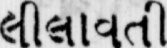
લીલાવતી
